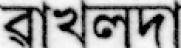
ৱাখলদা
